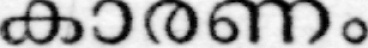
കാരണം
